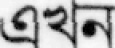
এখন
